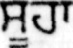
ਸੂਹਾ
